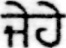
ਜੇਹੇ
